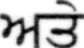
ਅਤੇ
